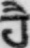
ਹੈ
